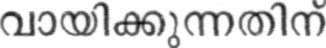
വായിക്കുന്നതിന്
